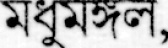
মধুমঙ্গল,
